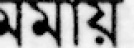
মমায়
